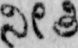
ನೀತಿ
